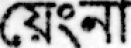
য়েংনা
